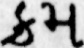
ક્રમ
